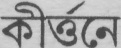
কীৰ্ত্তনে
